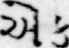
એક
